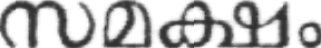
സമക്ഷം
